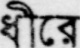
ধীরে
